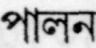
পালন
